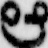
ಆ
